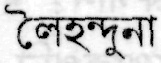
লৈহন্দুনা
